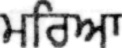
ਮਰਿਆ
